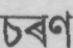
চৰণ
